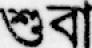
শুবা
